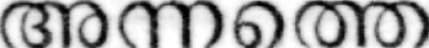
അന്നത്തെ
